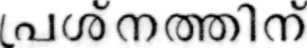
പ്രശ്നത്തിന്
